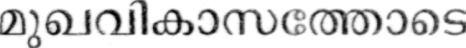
മുഖവികാസത്തോടെ
